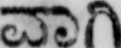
ವಾಗಿ
